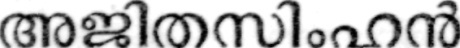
അജിതസിംഹന്‍
